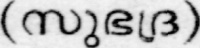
(സുഭദ്ര)
